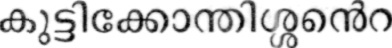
കുട്ടിക്കോന്തിശ്ശന്റെ
